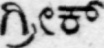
ಗ್ರೀಕ್
